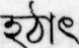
হঠাৎ
